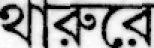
থারুরে
